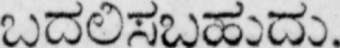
ಬದಲಿಸಬಹುದು.
